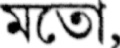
মতো,
